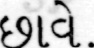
છાવે.
